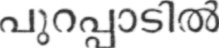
പുറപ്പാടില്‍
